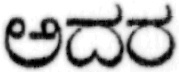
ಅದರ
